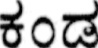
ಕಂಡ
